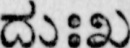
ದುಃಖ
